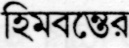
হিমবন্তের
